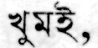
খুমই,
